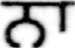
ਨਾ
